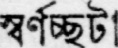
স্বর্ণচ্ছটা
